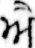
ਐ
